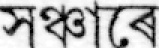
সঞ্চাৰে
